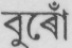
বুৰোঁ
